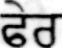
ਫੇਰ
